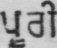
ਪੂਰੀ
